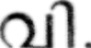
വി.
